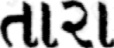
તારા
